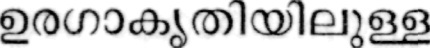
ഉരഗാകൃതിയിലുള്ള
